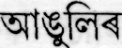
আঙুলিৰ
